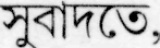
সুবাদতে,
